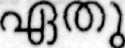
ഏതു
